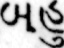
બહુ
